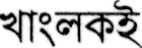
খাংলকই
